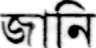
জানি
